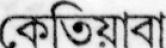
কেতিয়াবা
